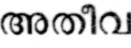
അതീവ
